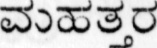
ಮಹತ್ತರ
